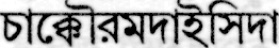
চাক্কৌরমদাইসিদা
